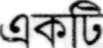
একটি
